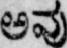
ಅವು
